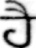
ਹੈ
